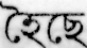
হৈছে
